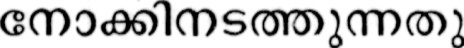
നോക്കിനടത്തുന്നതു
